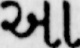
આ
